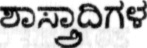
ಶಾಸ್ತ್ರಾದಿಗಳ
